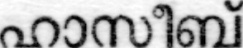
ഹാസീബ്
